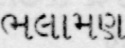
ભલામણ
